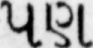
પણ
